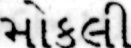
મોકલી
